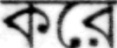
করে
